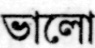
ভালো
